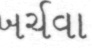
ખર્ચવા
